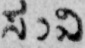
ಸಂವಿ
